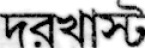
দরখাস্ট
